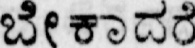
ಬೇಕಾದರೆ
